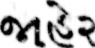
જાહેર
